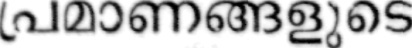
പ്രമാണങ്ങളുടെ
